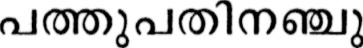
പത്തുപതിനഞ്ചു
